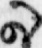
જે
